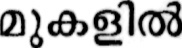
മുകളില്‍
